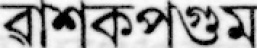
ৱাশকপগুম
